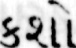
કશો
